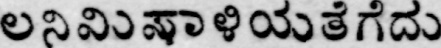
ಲನಿಮಿಷಾಳಿಯತೆಗೆದು
